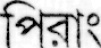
পিরাং
